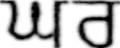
ਘਰ
